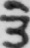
ਤੇ
